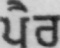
ਪੈਰ
